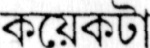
কয়েকটা
